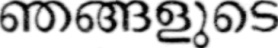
ഞങ്ങളുടെ
